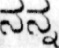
ನನ್ನ
